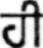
ਹੀ
